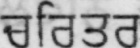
ਚਰਿਤਰ
